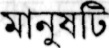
মানুষটি
